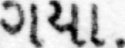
ગયા.
